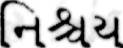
નિશ્ચય
